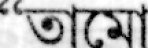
“তামো
